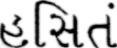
હસિતં
